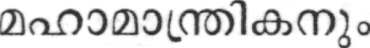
മഹാമാന്ത്രികനും
